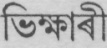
ভিক্ষাৰী
